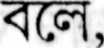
বলে,
